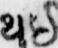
થઈ
